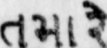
તમારે
